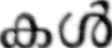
കള്‍
